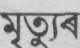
মৃত্যুৰ
